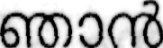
ഞാന്‍
